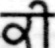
ਕੀ
